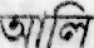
আলি
